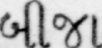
બીજા
